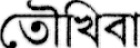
তৌখিবা
